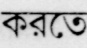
করতে
